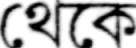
থেকে
